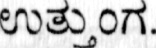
ಉತ್ತುಂಗ.
